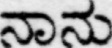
ನಾನು
